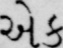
એક
